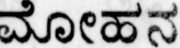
ಮೋಹನ
